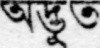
অদ্ভুত
